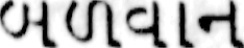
બળવાન
